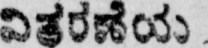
ವಿತರಣೆಯ
